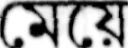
মেয়ে
